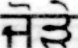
ਜੋੜੇ
